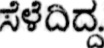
ಸೆಳೆದಿದ್ದ.
